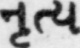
નૃત્ય
